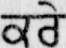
ਕਰੇ
